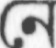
নে
